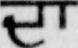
ਦਾ
